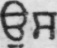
ਉਸ
